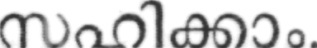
സഹിക്കാം.
